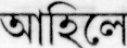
আহিলে
